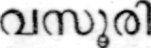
വസൂരി
